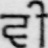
ਵੀ
